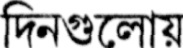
দিনগুলোয়
